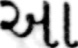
આ
